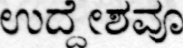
ಉದ್ದೇಶವೂ
